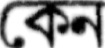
কেন
